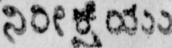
ನಿರೀಕ್ಷೆಯು
